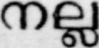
നല്ല
